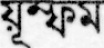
য়ূম্ফম
